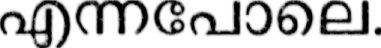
എന്നപോലെ.
